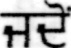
ਜਦੋਂ
